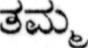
ತಮ್ಮ
